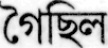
গৈছিল
